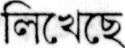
লিখেছে
